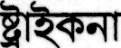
ষ্ট্রাইকনা
